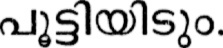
പൂട്ടിയിടും.
